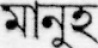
মানুহ
